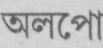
অলপো
